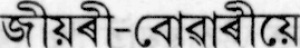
জীয়ৰী-বোৱাৰীয়ে
